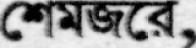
শেমজরে,
